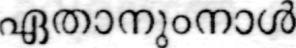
ഏതാനുംനാള്‍
